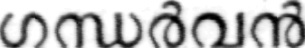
ഗന്ധര്‍വന്‍
